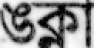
ঙক্না
